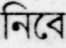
নিবে
